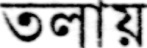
তলায়
